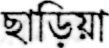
ছাড়িয়া
